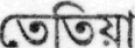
তেতিয়া
